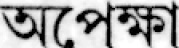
অপেক্ষা
